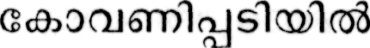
കോവണിപ്പടിയില്‍
